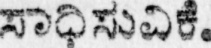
ಸಾಧಿಸುವಿಕೆ.
